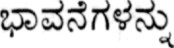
ಭಾವನೆಗಳನ್ನು
